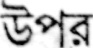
উপর
